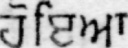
ਹੋਇਆ
